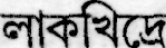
লাকখিদ্রে
